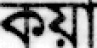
কয়া
